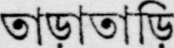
তাড়াতাড়ি
